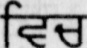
ਵਿਚ
